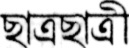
ছাত্রছাত্রী
